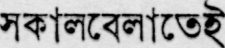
সকালবেলাতেই
